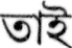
তাই
